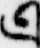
এ
